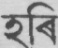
হৰি
